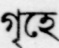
গৃহে
